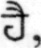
ਹੈ,
